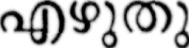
എഴുതു
